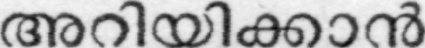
അറിയിക്കാന്‍
